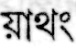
য়াথং
